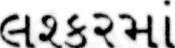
લશ્કરમાં
